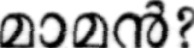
മാമന്‍?
